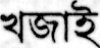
খজাই
